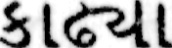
કાઢ્યા
